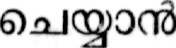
ചെയ്യാന്‍
